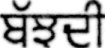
ਬੱਝਦੀ
